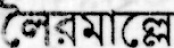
লৈরমাল্লে
